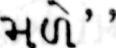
મળે"
